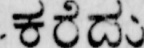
ಕರೆದು
